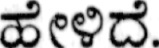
ಹೇಳಿದೆ.
